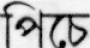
পিচে
